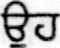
ਉਹ
